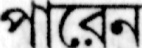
পারেন
